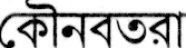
কৌনবতরা
